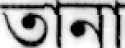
তানা
